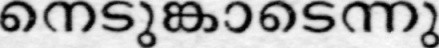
നെടുങ്കാടെന്നു
